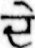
ਦੇ
